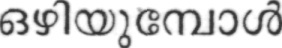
ഒഴിയുമ്പോള്‍
